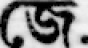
জে.
